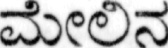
ಮೇಲಿನ
